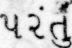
પરંતુ
